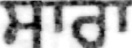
ਸਾਰਾ
